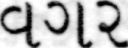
વગર
